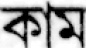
কাম
